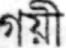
গয়ী
